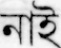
নাই
